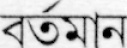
বর্তমান
